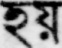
হয়
